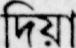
দিয়া
